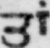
ਤਾਂ
